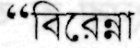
“বিরেন্না
